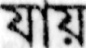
যায়
